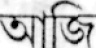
আজি
